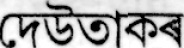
দেউতাকৰ
